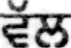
ਵੱਲ
